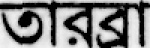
তারব্রা
